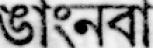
ঙাংনবা
